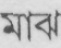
মাঝ
